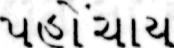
પહોંચાય
